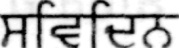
ਸਵਿਦਿਨ
